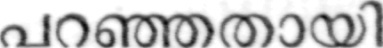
പറഞ്ഞതായി
